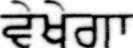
ਵੇਖੇਗਾ
